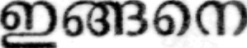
ഇങ്ങനെ
